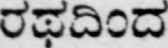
ರಥದಿಂದ
